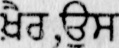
ਖ਼ੈਰ,ਉਸ
